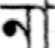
না
